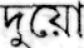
দুয়ো
